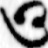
ও
